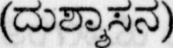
(ದುಶ್ಯಾಸನ)
